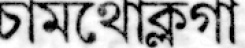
চামথোক্লগা
